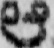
ಆ
